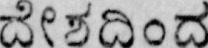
ದೇಶದಿಂದ
